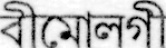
বীমোলগী
